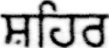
ਸ਼ਹਿਰ
